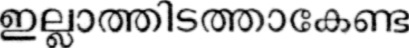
ഇല്ലാത്തിടത്താകേണ്ട
